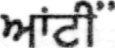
ਆਂਟੀ''
